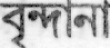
বৃন্দানা
